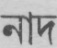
নাদ
